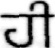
ਹੀ
